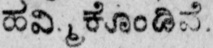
ಹಮ್ಮಿಕೊಂಡಿವೆ.
